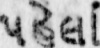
પહેલાં
